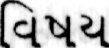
વિષય
